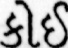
કોઈ
